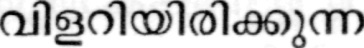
വിളറിയിരിക്കുന്ന
